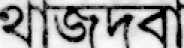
থাজদবা
